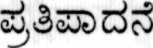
ಪ್ರತಿಪಾದನೆ
